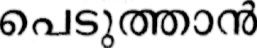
പെടുത്താന്‍
